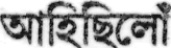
আহিছিলোঁ
